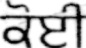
ਕੋਈ
